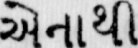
એનાથી
